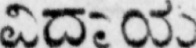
ವಿದಾಯ
